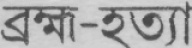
ব্ৰহ্ম-হত্যা
